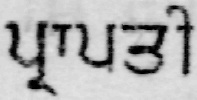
ਪ੍ਰਾਪਤੀ
